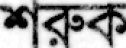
শরুক
